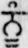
ਨੂੰ
